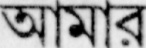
আমার
